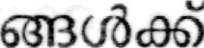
ങ്ങള്‍ക്ക്
